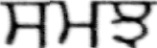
ਸਮਝ
